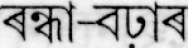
ৰন্ধা-বঢ়াৰ
